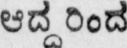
ಆದ್ದರಿಂದ
